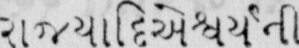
રાજ્યદિએશ્વર્યની
